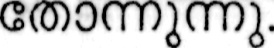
തോന്നുന്നു.
